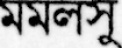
মমলসু
